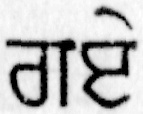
ਗਏ
